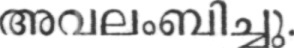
അവലംബിച്ചു.
